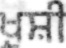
ਖੁਸ਼ੀ
